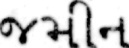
જમીન
